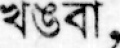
খঙবা,
